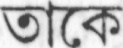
তাকে
